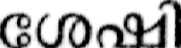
ശേഷി
